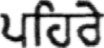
ਪਹਿਰੇ
